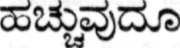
ಹಚ್ಚುವುದೂ
